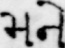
મને
